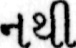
નથી
